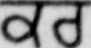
ਕਰ
